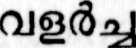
വളര്‍ച്ച
